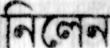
নিলেন
